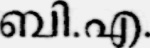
ബി.എ.
